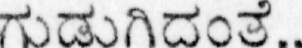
ಗುಡುಗಿದಂತೆ,
